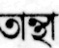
তান্থা
